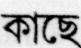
কাছে
